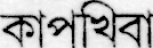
কাপখিবা
